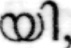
യി,
